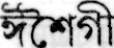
ঈশৈগী
